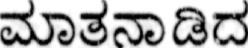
ಮಾತನಾಡಿದ
